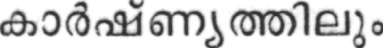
കാര്‍ഷ്ണ്യത്തിലും
